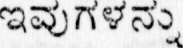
ಇವುಗಳನ್ನು
